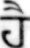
ਹੈ
